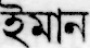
ইমান
